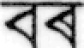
বৰ
